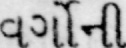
વર્ગોની
